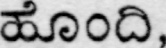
ಹೊಂದಿ,
